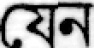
যেন
